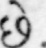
છે.
